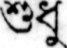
শুধু
